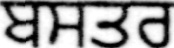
ਬਸਤਰ
